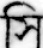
সি
